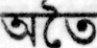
অতৈ
